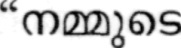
"നമ്മുടെ
